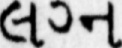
લગ્ન
